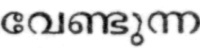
വേണ്ടുന്ന
